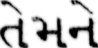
તેમને
